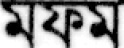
মফম
